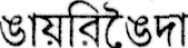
ঙায়রিঙৈদা
